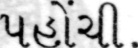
પહોંચી.
